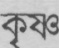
কৃষ্ণ
